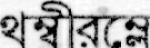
থম্বীরম্লে
